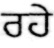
ਰਹੇ
